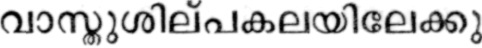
വാസ്തുശില്പകലയിലേക്കു
